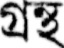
গ্রন্থ
